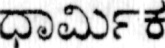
ಧಾರ್ಮಿಕ
